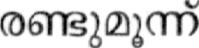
രണ്ടുമൂന്ന്
